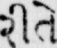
રીતે
